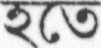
হতে
